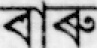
বাৰু
